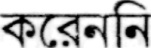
করেননি
